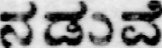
ನಡುವೆ
